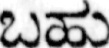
ಬಹು
